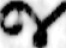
જ
